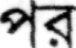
পর
